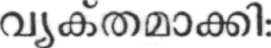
വ്യക്തമാക്കി:
